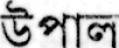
উপাল
